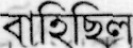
বাহিছিল
